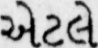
એટલે
